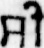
ਸੀ
